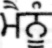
ਮੈਨੂੰ
